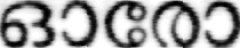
ഓരോ
